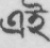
এই
